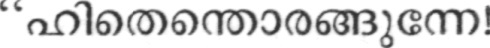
"ഹിതെന്തൊരങ്ങുന്നേ!
